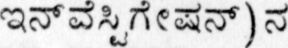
ಇನ್‌ವೆಸ್ಟಿಗೇಷನ್)ನ
